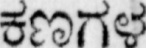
ಕಣಗಳ
